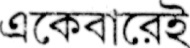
একেবারেই
